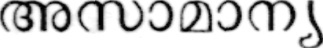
അസാമാന്യ
